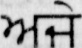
ਅਜੇ
